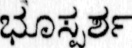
ಭೂಸ್ಪರ್ಶ
